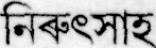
নিৰুৎসাহ
